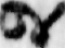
જ
